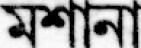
মশানা
